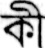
কী
